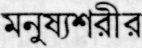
মনুষ্যশরীর
